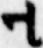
ન
